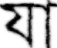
যা
